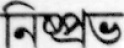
নিষ্প্রভ
